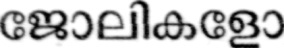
ജോലികളോ
